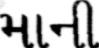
માની
